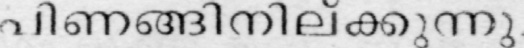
പിണങ്ങിനില്ക്കുന്നു.
